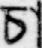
চা
